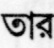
তার
